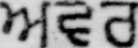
ਅਵਰ
